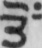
ਤੋਂ
